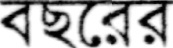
বছরের
